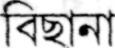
বিছানা
